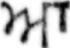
ਆ
